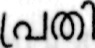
പ്രതി
